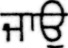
ਜਾਉ
